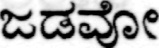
ಜಡವೋ
